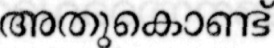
അതുകൊണ്ട്
